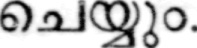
ചെയ്യും.
